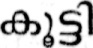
കൂട്ടി
